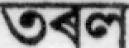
তৰল
